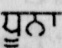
ਧੂਨਾ
